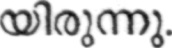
യിരുന്നു.
